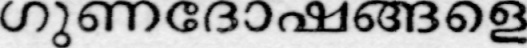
ഗുണദോഷങ്ങളെ
